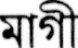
মাগী
